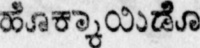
ಹೊಕ್ಕಾಯಿಡೊ
